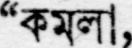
‘‘কমলা,
